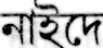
নাইদে
